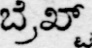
ಬ್ರೆಖ್ಟ್
